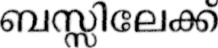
ബസ്സിലേക്ക്
